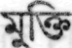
মুক্তি
